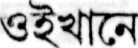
ওইখানে
